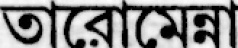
তারোমেন্না
